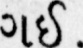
ગઈ.
